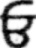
ਓ
